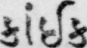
કાંઈક
